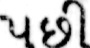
પછી
